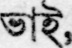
ভাই,
